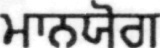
ਮਾਨਯੋਗ
